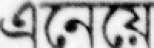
এনেয়ে
